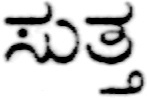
ಸುತ್ತ
